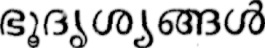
ഭൂദൃശ്യങ്ങള്‍
